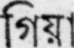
গিয়া
